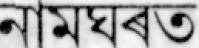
নামঘৰত
